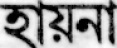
হায়না
